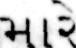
મારે
